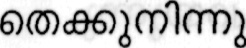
തെക്കുനിന്നു
